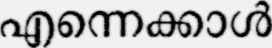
എന്നെക്കാള്‍
